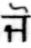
ਜੋ
